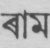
ৰাম
